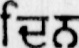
ਦਿਨ
